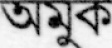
অমুক
